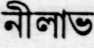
নীলাভ
